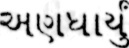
અણધાર્યું
